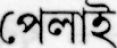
পেলাই
